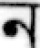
ন
